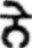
ਨੇ
